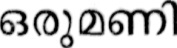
ഒരുമണി
